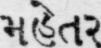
મહેતર
